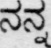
ನನ್ನ
